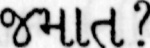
જમાત?
